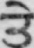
ਤੇ
